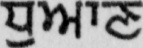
ਧੁਆਣ
